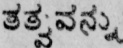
ತತ್ವವನ್ನು
